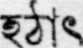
হঠাৎ
